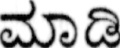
ಮಾಡಿ
